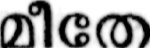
മീതേ
